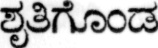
ಶೃತಿಗೊಂಡ
